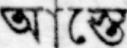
আস্তে
